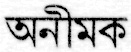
অনীমক
